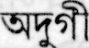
অদুগী
